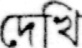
দেখি
